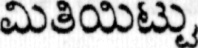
ಮಿತಿಯಿಟ್ಟು
